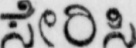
ಸೇರಿಸಿ
